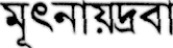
মূৎনায়দ্রবা
